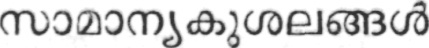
സാമാന്യകുശലങ്ങള്‍
